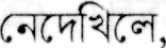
নেদেখিলে,
